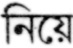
নিয়ে
